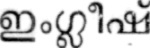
ഇംഗ്ലീഷ്
